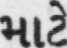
માટે
